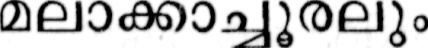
മലാക്കാച്ചൂരലും
